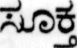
ಸೂಕ್ತ
